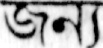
জন্য
